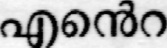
എന്റെ
